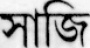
সাজি
